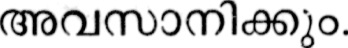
അവസാനിക്കും.
